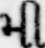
મી
